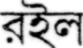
রইল
